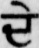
ਦੇ
